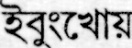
ইবুংখোয়
